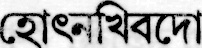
হোৎনখিবদো
